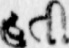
હતી
